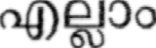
എല്ലാം
